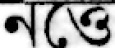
নত্তে
